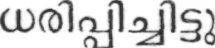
ധരിപ്പിച്ചിട്ടു
